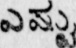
ಎಷ್ಟು
